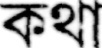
কথা
